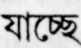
যাচ্ছে
